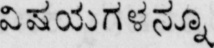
ವಿಷಯಗಳನ್ನೂ
